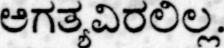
ಅಗತ್ಯವಿರಲಿಲ್ಲ.
